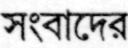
সংবাদের
